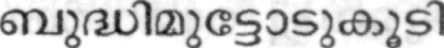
ബുദ്ധിമുട്ടോടുകൂടി
